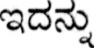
ಇದನ್ನು
